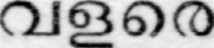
വളരെ
